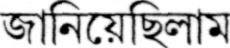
জানিয়েছিলাম
